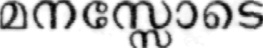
മനസ്സോടെ
